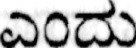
ಎಂದು
